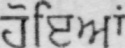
ਹੋਇਆਂ
